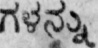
ಗಳನ್ನು
